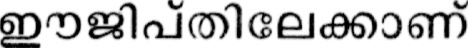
ഈജിപ്തിലേക്കാണ്
